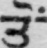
ਤੋਂ
